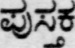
ಪುಸ್ತಕ
